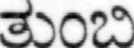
ತುಂಬಿ
